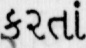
કરતાં
